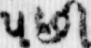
પછી
